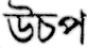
উচপ
